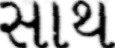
સાથ
